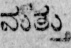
ಮತ್ತು
